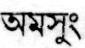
অমসুং
